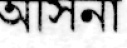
অসিনা
